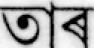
তাৰ
